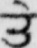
ਤੇ
